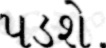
પડશે.
